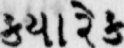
ક્યારેક
